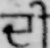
ਦੀ
